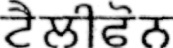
ਟੈਲੀਫੋਨ
